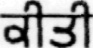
ਕੀਤੀ
